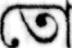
তো
